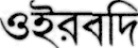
ওইরবদি
